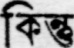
কিন্তু
